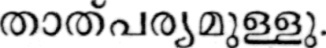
താത്പര്യമുള്ളു.
